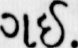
ગઈ.
